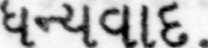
ધન્યવાદ.
